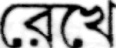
রেখে
